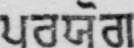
ਪਰਯੋਗ
